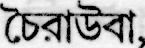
চৈরাউবা,
